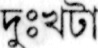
দুঃখটা
